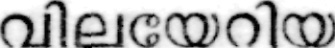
വിലയേറിയ
